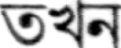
তখন
